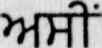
ਅਸੀਂ
